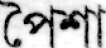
পৈশা
